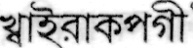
খ্বাইরাকপগী
